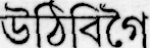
উঠিবিগৈ
